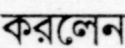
করলেন
